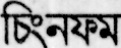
চিংনফম
